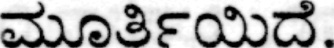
ಮೂರ್ತಿಯಿದೆ.
